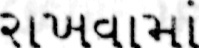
રાખવામાં
